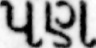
પણ
